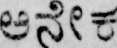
ಅನೇಕ
